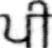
ਪੀ
